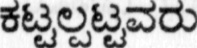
ಕಟ್ಟಲ್ಪಟ್ಟವರು
